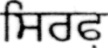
ਸਿਰਫ਼
